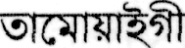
তামোয়াইগী
